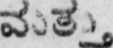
ಮತ್ತು
